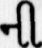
ની
